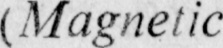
(Magnetic
